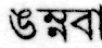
ঙম্নবা
